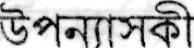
উপন্যাসকী
